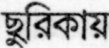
ছুরিকায়
